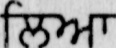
ਲਿਆ
